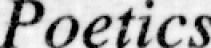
Poetics
